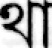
থা
